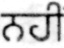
ਨਹੀਂ
